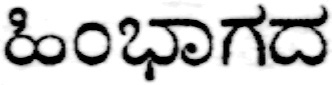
ಹಿಂಭಾಗದ
